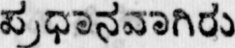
ಪ್ರಧಾನವಾಗಿರು
